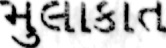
મુલાકાત
